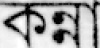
কন্না
